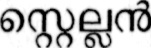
സ്റ്റെല്ലന്‍
